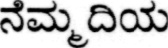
ನೆಮ್ಮದಿಯ
